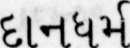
દાનધર્મ
